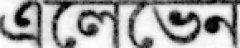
এলেভেন
